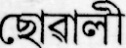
ছোৱালী
